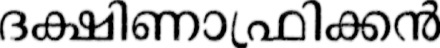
ദക്ഷിണാഫ്രിക്കന്‍
